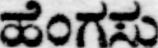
ಹೆಂಗಸು
